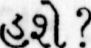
હશે?
